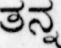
ತನ್ನ
